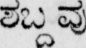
ಶಬ್ದವು
